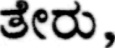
ತೇರು,
